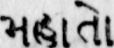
મહાતો
